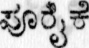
ಪೂರೈಕೆ
